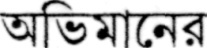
অভিমানের
